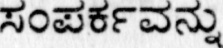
ಸಂಪರ್ಕವನ್ನು
